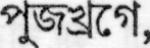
পুজখ্রগে,
